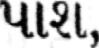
પાશ,
